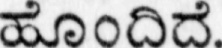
ಹೊಂದಿದೆ.
